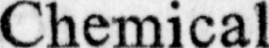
Chemical
